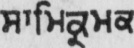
ਸਾਮਿਕ੍ਰਮਕ
